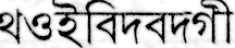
থওইবিদবদগী
